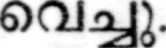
വെച്ചു.
